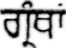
ਗ੍ਰੰਥਾਂ
